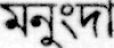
মনুংদা
